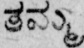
ತಮ್ಮ
